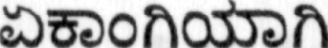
ಏಕಾಂಗಿಯಾಗಿ
